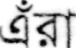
এঁরা
